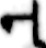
ન
